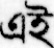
এই
